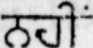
ਨਹੀਂ
